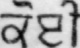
ਕੋਈ
